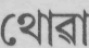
থোৱা
